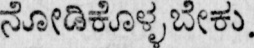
ನೋಡಿಕೊಳ್ಳಬೇಕು.
